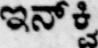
ಇನ್‌ಕ್ವಿ
